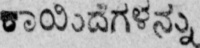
ಕಾಯಿದೆಗಳನ್ನು
